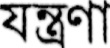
যন্ত্রণা
